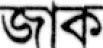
জাক
